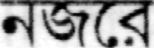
নজরে
